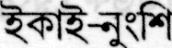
ইকাই-নুংশি
